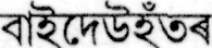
বাইদেউহঁতৰ
